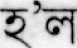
হ'ল
